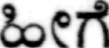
ಹೀಗೆ
